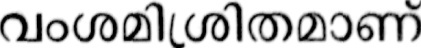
വംശമിശ്രിതമാണ്
